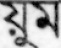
য়ুম
